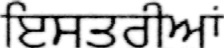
ਇਸਤਰੀਆਂ
